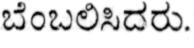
ಬೆಂಬಲಿಸಿದರು.
